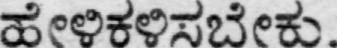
ಹೇಳಿಕಳಿಸಬೇಕು.
